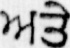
ਅਤੇ
